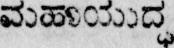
ಮಹಾಯುದ್ದ
